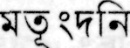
মতূংদনি
